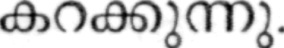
കറക്കുന്നു.
